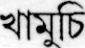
খামুচি
